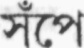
সঁপে
